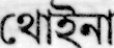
থোইনা
